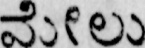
ಮೇಲು
